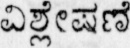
ವಿಶ್ಲೇಷಣೆ
